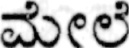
ಮೇಲೆ
